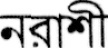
নরাশী
